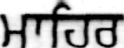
ਮਾਹਿਰ
